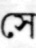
সে
